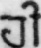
ਹੀ
